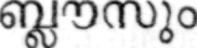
ബ്ലൌസും
